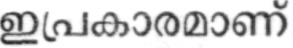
ഇപ്രകാരമാണ്
